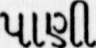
પાણી
